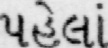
પહેલાં
